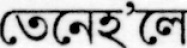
তেনেহ'লে
